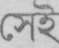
সেই
